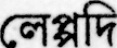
লেপ্পদি
